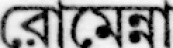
রোমেন্না
